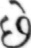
છે
